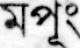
মপূং
